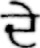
ਦੇ
